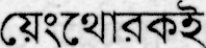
য়েংথোরকই
